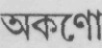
অকণো
